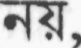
নয়,
